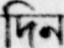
দিন
